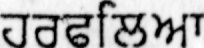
ਹਰਫਲਿਆ
